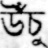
উঁচু
